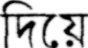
দিয়ে
